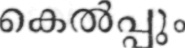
കെല്‍പ്പും
